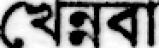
খেন্নবা
